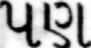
પણ
